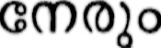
നേരും
